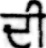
ਦੀ
